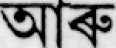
আৰু
